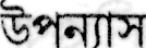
উপন্যাস
